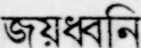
জয়ধ্বনি
